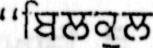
''ਬਿਲਕੁਲ
